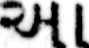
આ
